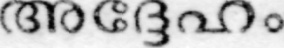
അദ്ദേഹം
